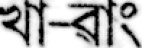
খা-ৱাং
